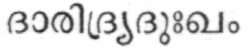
ദാരിദ്ര്യദുഃഖം
